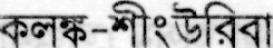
কলঙ্ক-শীংউরিবা
